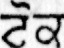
ਟੋਕ
